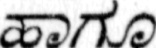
ಹಾಗೂ
